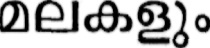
മലകളും
